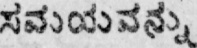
ಸಮಯವನ್ನು
